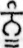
ਨੂੰ
